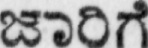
ಜಾರಿಗೆ
